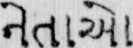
નેતાઓ
